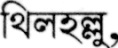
থিলহল্লু,
